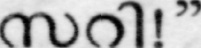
സറി!"
